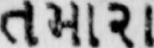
તમારા
